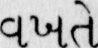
વખતે
